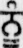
ਨੂੰ
